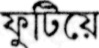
ফুটিয়ে
